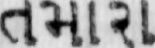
તમારા
